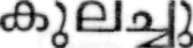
കുലച്ചു
